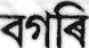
বগৰি
